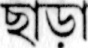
ছাড়া
